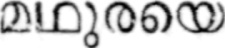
മഥുരയെ
